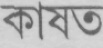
কাষত
